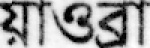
য়াওব্রা
